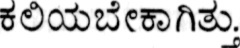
ಕಲಿಯಬೇಕಾಗಿತ್ತು.
